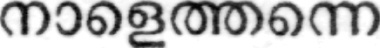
നാളെത്തന്നെ
